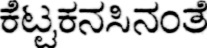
ಕೆಟ್ಟಕನಸಿನಂತೆ
